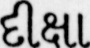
દીક્ષા
